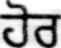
ਹੋਰ
